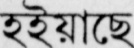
হইয়াছে
